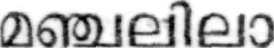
മഞ്ചലിലാ
